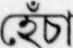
হেঁচা
